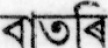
বাতৰি
